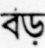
বড়
